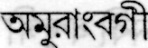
অমুরাংবগী
